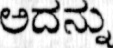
ಅದನ್ನು
